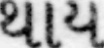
થાય
